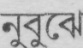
নুবুঝে
